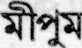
মীপুম
